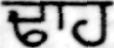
ਢਾਹ
